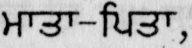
ਮਾਤਾ-ਪਿਤਾ,
